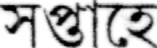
সপ্তাহে
